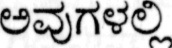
ಅವುಗಳಲ್ಲಿ
